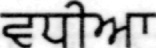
ਵਧੀਆ
